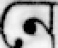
নে
